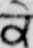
ਕੇ
